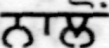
ਨਾਲੋਂ
